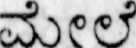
ಮೇಲೆ
